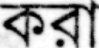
করা
